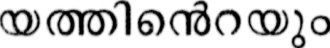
യത്തിന്റെയും
